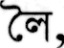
লৈ,
